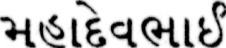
મહાદેવભાઈ
